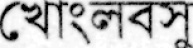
খোংলবসু
